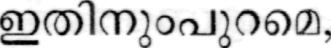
ഇതിനുംപുറമെ,
